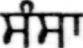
ਸੰਸਾ
